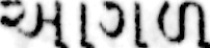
આગળ
